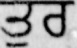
ਤੁਰ
